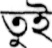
তুই
